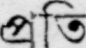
প্রতি
